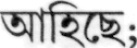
আহিছে;
